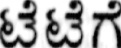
ಟೆಟೆಗೆ
